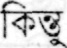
কিন্তু
